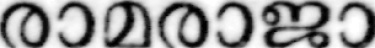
രാമരാജാ
